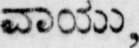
ವಾಯು,
